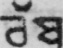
ਰੱਬ
